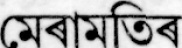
মেৰামতিৰ
